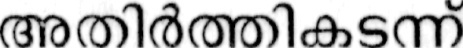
അതിര്‍ത്തികടന്ന്
